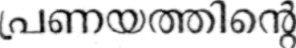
പ്രണയത്തിന്റെ
